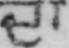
ਦਾ
